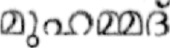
മുഹമ്മദ്
